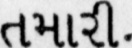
તમારી
